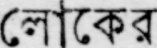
লোকের
